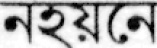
নহয়নে
